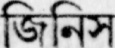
জিনিস
